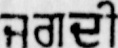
ਜਗਦੀ
